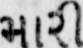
મારી
